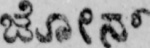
ಜೋನ್
